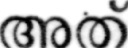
അത്
